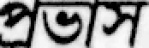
প্রভাস
